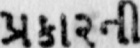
પ્રકારની
